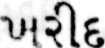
ખરીદ
